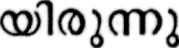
യിരുന്നു
